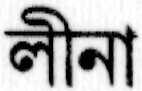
লীনা
